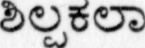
ಶಿಲ್ಪಕಲಾ
